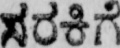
ಸರಕಿಗೆ
